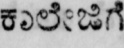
ಕಾಲೇಜಿಗೆ
